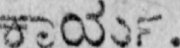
ಕಾರ್ಯ.
